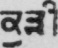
ਕੁੜੀ
